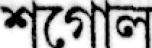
শগোল
